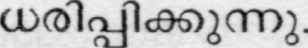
ധരിപ്പിക്കുന്നു.
